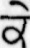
ਕੇ
